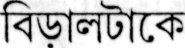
বিড়ালটাকে
